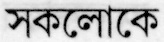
সকলোকে
